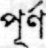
পূর্ণ
